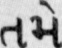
તમે
